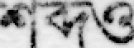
শব্দও
